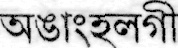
অঙাংহলগী
